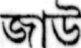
জাউ
